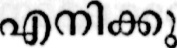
എനിക്കു
